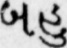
બહુ
